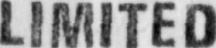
LIMITED
